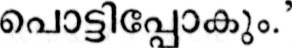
പൊട്ടിപ്പോകും.'
